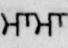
ਮਾਮਾ
